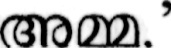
അമ്മ.’
